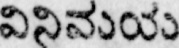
ವಿನಿಮಯ
